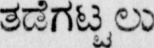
ತಡೆಗಟ್ಟಲು
